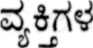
ವ್ಯಕ್ತಿಗಳ
